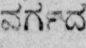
ವರ್ಗದ
